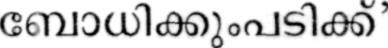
ബോധിക്കുംപടിക്ക്'
